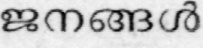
ജനങ്ങള്‍
